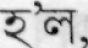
হ'ল,
